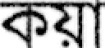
কয়া
